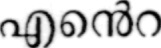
എന്റെ
